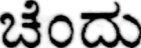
ಚೆಂದು
